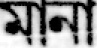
মানা
